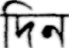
দিন
